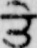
ਤੇ
